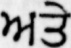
ਅਤੇ
